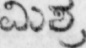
ಮಿಶ್ರ
